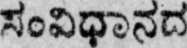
ಸಂವಿಧಾನದ
